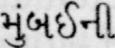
મુંબઈની
